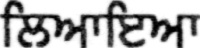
ਲਿਆਇਆ
